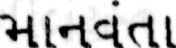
માનવંતા
